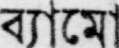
ব্যামো
